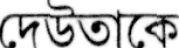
দেউতাকে
